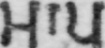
ਮਾਪ
